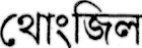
থোংজিল
